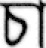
চা
